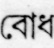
বোধ
